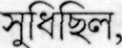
সুধিছিল,
